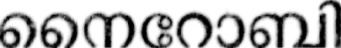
നൈറോബി
